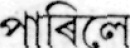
পাৰিলে
